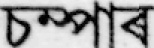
চম্পাৰ
